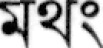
মথং
